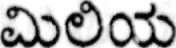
ಮಿಲಿಯ
